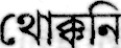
থোক্কনি
